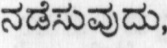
ನಡೆಸುವುದು,
